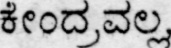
ಕೇಂದ್ರವಲ್ಲ,
